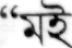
"মই
